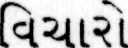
વિચારો
